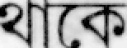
থাকে
